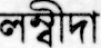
লম্বীদা
